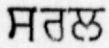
ਸਰਲ
